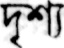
দৃশ্য
